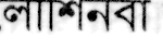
লৌশিনবা
